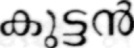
കുട്ടന്‍
